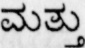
ಮತ್ತು
